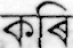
কৰি
